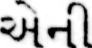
એની
